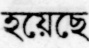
হয়েছে
